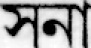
সনা
